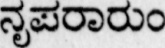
ನೃಪರಾರುಂ
